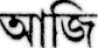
আজি
